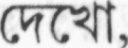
দেখো,
